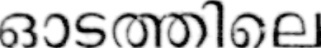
ഓടത്തിലെ
